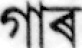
গাৰ
